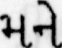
મને
